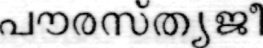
പൌരസ്ത്യജീ
